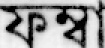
ফম্বা
